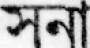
সনা
